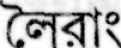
লৈরাং
